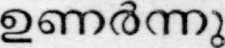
ഉണര്‍ന്നു
